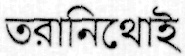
তরানিথোই
